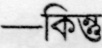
–কিন্তু
